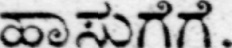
ಹಾಸುಗೆಗೆ.
